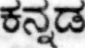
ಕನ್ನಡ
